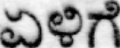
ಏಳಿಗೆ
